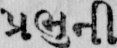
પ્રભુની
